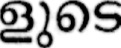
ളുടെ
